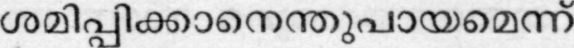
ശമിപ്പിക്കാനെന്തുപായമെന്ന്
